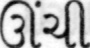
ઊંચી
